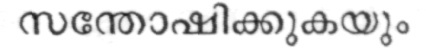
സന്തോഷിക്കുകയും
